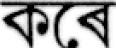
কৰে
